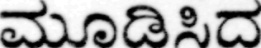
ಮೂಡಿಸಿದ
